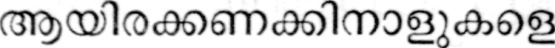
ആയിരക്കണക്കിനാളുകളെ
